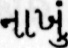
નાખું
